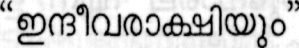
"ഇന്ദീവരാക്ഷിയും"
